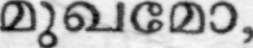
മുഖമോ,
